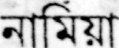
নামিয়া
